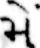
મેં
